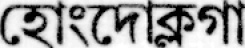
হোংদোক্লগা
